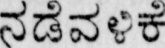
ನಡೆವಳಿಕೆ
